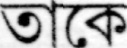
তাকে
